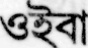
ওইবা
